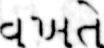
વખતે
